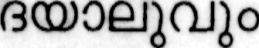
ദയാലുവും
